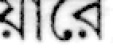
য়ারে
